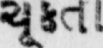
ચૂકતા
